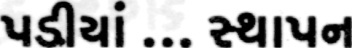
પડીયાં...સ્થાપન
